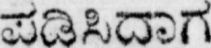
ಪಡಿಸಿದಾಗ
